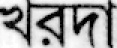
খরদা
